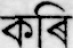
কৰি
